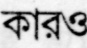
কারও
